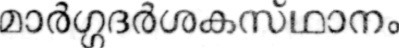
മാര്‍ഗ്ഗദര്‍ശകസ്ഥാനം
